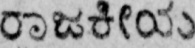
ರಾಜಕೀಯ
